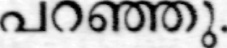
പറഞ്ഞു.
